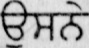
ਉਸਨੇ
